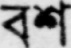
বশ
